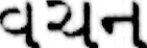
વચન
